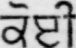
ਕੋਈ
